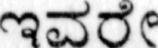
ಇವರೇ
